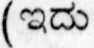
(ಇದು
